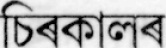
চিৰকালৰ
